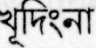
খূদিংনা
